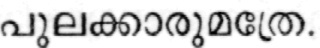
പുലക്കാരുമത്രേ.
